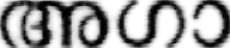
അഗാ
